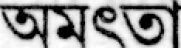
অমৎতা
